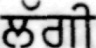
ਲੱਗੀ
